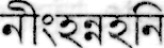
নীংহন্নহনি
